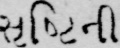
સૃષ્ટિની
